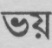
ভয়
